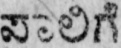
ಪಾಲಿಗೆ
